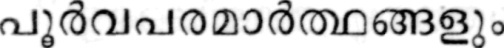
പൂര്‍വപരമാര്‍ത്ഥങ്ങളും
